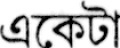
একেটা
